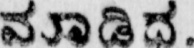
ಮಾಡಿದ.
